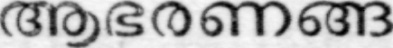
ആഭരണങ്ങ
